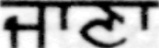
ਜਾਣਾ
